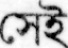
সেই
